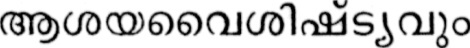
ആശയവൈശിഷ്ട്യവും
